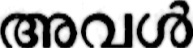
അവള്‍
